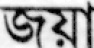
জয়া
